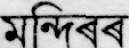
মন্দিৰৰ
